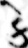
કે
